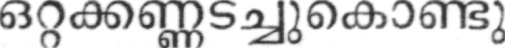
ഒറ്റക്കണ്ണടച്ചുകൊണ്ടു
